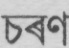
চৰণ
